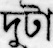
দুটা
